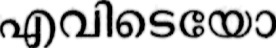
എവിടെയോ
